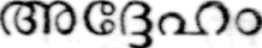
അദ്ദേഹം
